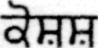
ਕੋਸ਼ਸ਼
